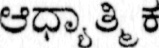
ಆಧ್ಯಾತ್ಮಿಕ
